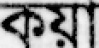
কয়া
